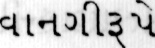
વાનગીરૂપે
